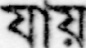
যায়
